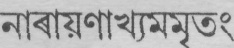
নাৰায়ণাখ্যমমৃতং
